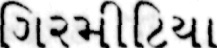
ગિરમીટિયા
